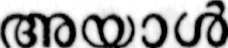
അയാള്‍
